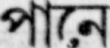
পানে
